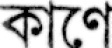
কাণে
